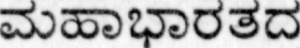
ಮಹಾಭಾರತದ
